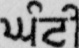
ਘੰਟੀ
